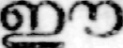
ഈ
